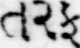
તરફ
